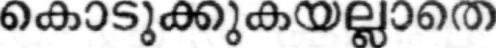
കൊടുക്കുകയല്ലാതെ
